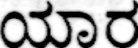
ಯಾರ
